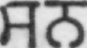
ਸਨ
